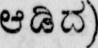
ಆಡಿದ)
